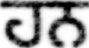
ਹਨ
